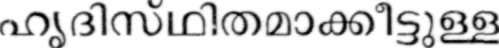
ഹൃദിസ്ഥിതമാക്കീട്ടുള്ള
